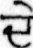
ਦੇ
